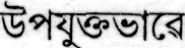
উপযুক্তভাৱে
